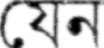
যেন
